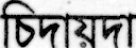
চিদায়াদ
